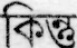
কিন্তু
